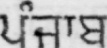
ਪੰਜਾਬ
